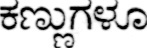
ಕಣ್ಣುಗಳೂ
